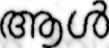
ആള്‍
